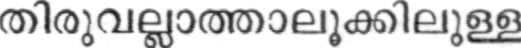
തിരുവല്ലാത്താലൂക്കിലുള്ള
